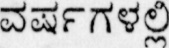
ವರ್ಷಗಳಲ್ಲಿ
